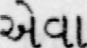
એવા
